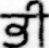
ਭੀ
